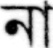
না
